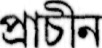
প্রাচীন
